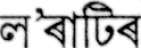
ল'ৰাটিৰ
